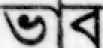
ভাব
